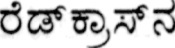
ರೆಡ್ ಕ್ರಾಸ್ ನ
